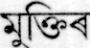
মুক্তিৰ
